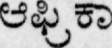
ಆಫ್ರಿಕಾ
